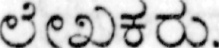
ಲೇಖಕರು.
